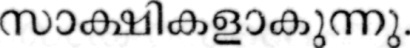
സാക്ഷികളാകുന്നു.
